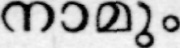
നാമും
